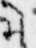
મેં
